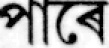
পাৰে
